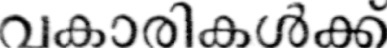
വകാരികള്‍ക്ക്
